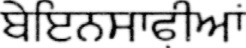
ਬੇਇਨਸਾਫ਼ੀਆਂ
